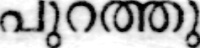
പുറത്തു
